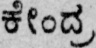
ಕೇಂದ್ರ
